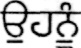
ਉਹਨੂੰ
